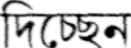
দিচ্ছেন
